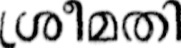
ശ്രീമതി
